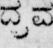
ದ್ರವ
